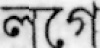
লগে
